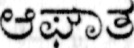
ಆಘಾತ
